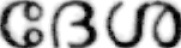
ദേശ
